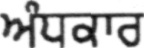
ਅੰਧਕਾਰ
